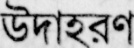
উদাহরণ
